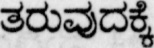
ತರುವುದಕ್ಕೆ
